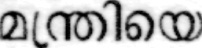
മന്ത്രിയെ
